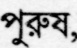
পুরুষ,
